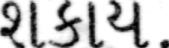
શકાય.
